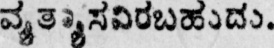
ವ್ಯತ್ಯಾಸವಿರಬಹುದು.
